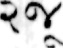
રજૂ
